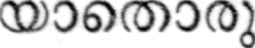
യാതൊരു
